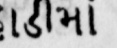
હોડીમાં
